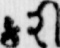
કરી
